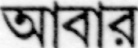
আবার
